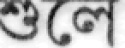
শুলে
